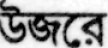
উজরে
